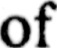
of
